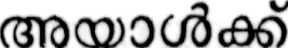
അയാള്‍ക്ക്
